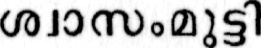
ശ്വാസംമുട്ടി
